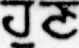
ਹੁਣ
